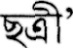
ছত্রী'
